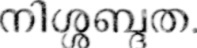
നിശ്ശബ്ദത.
